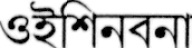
ওইশিনবনা
